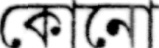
কোনো
